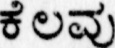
ಕೆಲವು
